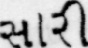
સારી
